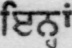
ਇਨ੍ਹਾਂ
